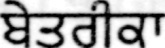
ਬੇਤਰੀਕਾ
